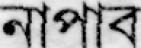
নাপাব
